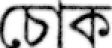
চোক
